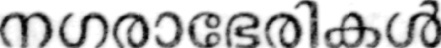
നഗരാഭേരികള്‍
